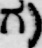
ಗ)
